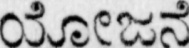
ಯೋಜನೆ
